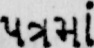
પત્રમાં
